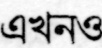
এখনও
